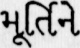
મૂર્તિને
